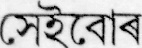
সেইবোৰ
